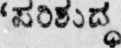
‘ಪರಿಶುದ್ಧ
